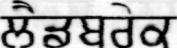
ਲੈਡਬਰੇਕ
